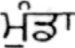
ਮੁੰਡਾ
